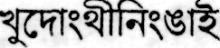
খুদোংথীনিংঙাই
